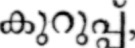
കുറുപ്പ്,
